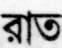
রাত
